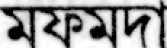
মফমদা
